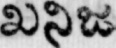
ಖನಿಜ
